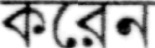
করেন
